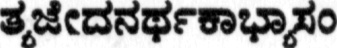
ತ್ಯಜೇದನರ್ಥಕಾಭ್ಯಾಸಂ
